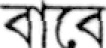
বাবে
